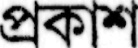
প্রকাশ
